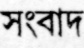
সংবাদ
